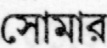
সোমার
